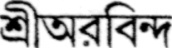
শ্রীঅরবিন্দ
